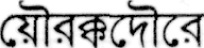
য়ৌরক্কদৌরে
